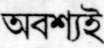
অবশ্যই
